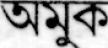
অমুক
